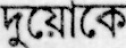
দুয়োকে
